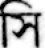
সি
